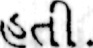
હતી.
